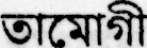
তামোগী
